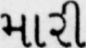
મારી
